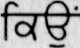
ਕਿਉਂ
